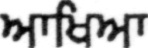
ਆਖਿਆ
